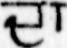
ਦਾ
